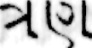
ત્રણ
